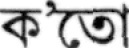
ক'তো
